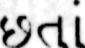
છતાં
